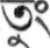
তুং
